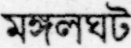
মঙ্গলঘট
